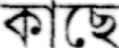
কাছে
